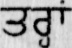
ਤਰ੍ਹਾਂ
